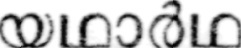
യഥാര്‍ഥ
